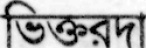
ভিক্তরদা
